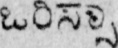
ಒರಿಸ್ಸಾ
